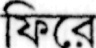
ফিরে
